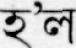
হ'ল
